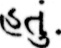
હતું.
